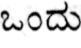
ಒಂದು
